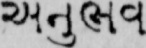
અનુભવ
